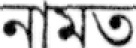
নামত
